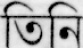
তিনি
